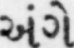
અંગે
